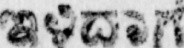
ಇಳಿದಾಗ
